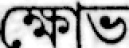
ক্ষোভ
